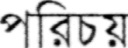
পরিচয়
